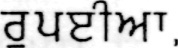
ਰੁਪਈਆ,
